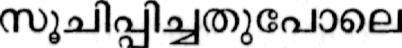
സൂചിപ്പിച്ചതുപോലെ
